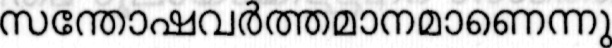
സന്തോഷവര്‍ത്തമാനമാണെന്നു
